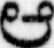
ಆ
